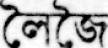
লৈজৈ
